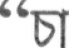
“চা
